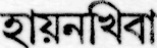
হায়নখিবা
